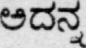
ಅದನ್ನ
